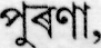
পুৰণা,
